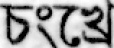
চংখ্রে
